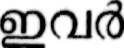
ഇവര്‍
